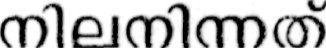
നിലനിന്നത്
